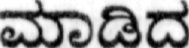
ಮಾಡಿದ
